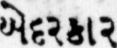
બેદરકાર
